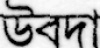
উবদা
